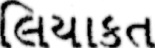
લિયાકત
